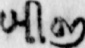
બીજી
